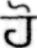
ਹੋ
